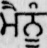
ਮੈਨੂੰ
